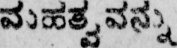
ಮಹತ್ವವನ್ನು
